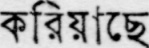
করিয়াছে
